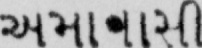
અમાવાસી
